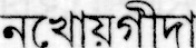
নখোয়গীদা
